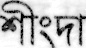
শীংদা
